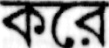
করে
